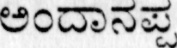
ಅಂದಾನಪ್ಪ
